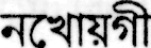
নখোয়গী
